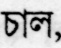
চাল,
